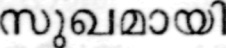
സുഖമായി
